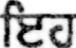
ਇਹ
